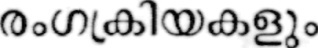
രംഗക്രിയകളും
